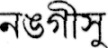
নঙগীসু
